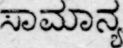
ಸಾಮಾನ್ಯ
